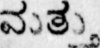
ಮತ್ತು
